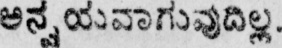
ಅನ್ವಯವಾಗುವುದಿಲ್ಲ.
